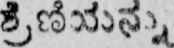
ಶ್ರೇಣಿಯನ್ನು
